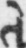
તે
